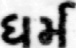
ધર્મ
